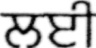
ਲਈ
